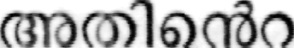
അതിന്റെ
